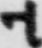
ન
